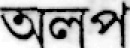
অলপ
